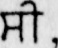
ਸੀ,
